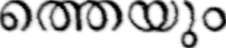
ത്തെയും
